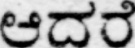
ಆದರೆ
